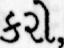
કરો,
